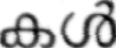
കള്‍
